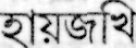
হায়জখি
